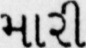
મારી
